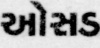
ઓસડ
